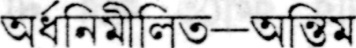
অর্ধনিমীলিত—অন্তিম
